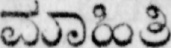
ಮಾಹಿತಿ
